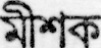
মীশক
